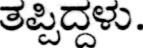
ತಪ್ಪಿದ್ದಳು.
